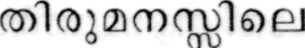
തിരുമനസ്സിലെ
